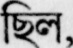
ছিল,
